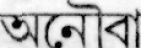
অনৌবা
